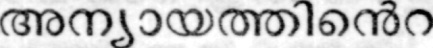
അന്യായത്തിന്റെ
